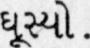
ઘૂસ્યો.
